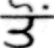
ਤੋ
